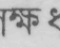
লক্ষ
